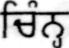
ਚਿੰਨ੍ਹ
